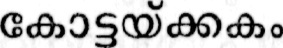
കോട്ടയ്ക്കകം
